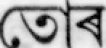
তোৰ
